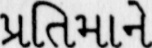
પ્રતિમાને
